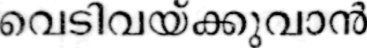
വെടിവയ്ക്കുവാന്‍
